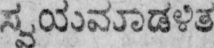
ಸ್ವಯಮಾಡಳಿತ
